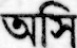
অসি
